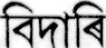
বিদাৰি
